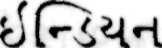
ઈન્ડિયન
